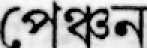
পেঞ্চন
